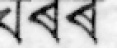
ঘৰৰ
